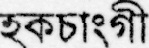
হকচাংগী
